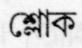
শ্লোক
